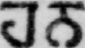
ਹਨ
